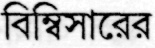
বিম্বিসারের
